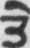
ਤੇ
